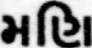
મણિ
